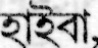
হাইবা,
